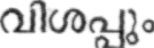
വിശപ്പും
